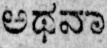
ಅಥವಾ
